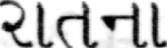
રાતના
